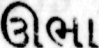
ઊભા
